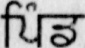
ਪਿੰਡ
